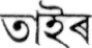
তাইৰ
